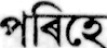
পৰিহে
